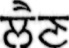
ਲੈਣ
